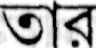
তার
